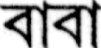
বাবা
